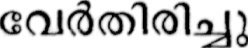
വേര്‍തിരിച്ചു
